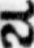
ನ
